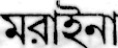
মরাইনা
